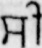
ਸੀ
